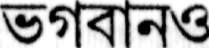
ভগবানও
